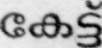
കേട്ട്
